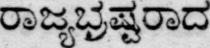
ರಾಜ್ಯಭ್ರಷ್ಟರಾದ
